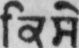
ਕਿਸੇ
